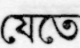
যেতে
